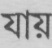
যায়
